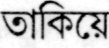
তাকিয়ে
